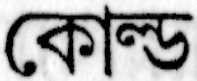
কোল্ড
